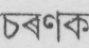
চৰণক
